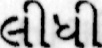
લીધી
